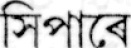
সিপাৰে
